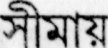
সীমায়
